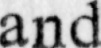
and
